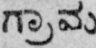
ಗ್ರಾಮ
